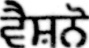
ਵੈਸ਼ਨੋ
